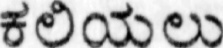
ಕಲಿಯಲು
